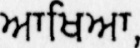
ਆਖਿਆ,
